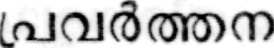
പ്രവര്‍ത്തന
